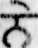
ਨੇ
